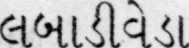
લબાડીવેડા
